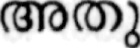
അതു
